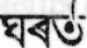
ঘৰত
